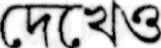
দেখেও
